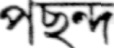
পছন্দ
